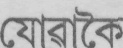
যোৱাকৈ
